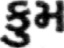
કુમ
